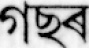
গছৰ
